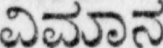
ವಿಮಾನ
